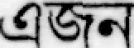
এজন
